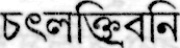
চৎলক্ত্রিবনি
